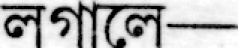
লগালে-
